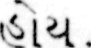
હોય.
